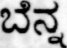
ಬೆನ್ನ
